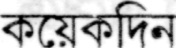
কয়েকদিন
